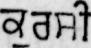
ਕੁਰਸੀ
